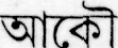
আকৌ
